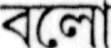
বলো
